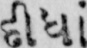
દીધાં
